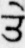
ਤੇ
